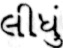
લીધું
